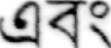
এবং
